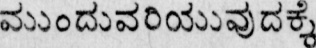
ಮುಂದುವರಿಯುವುದಕ್ಕೆ
